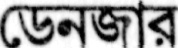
ডেনজার
